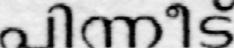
പിന്നീട്
